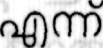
എന്ന്
